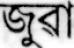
জুৱা
